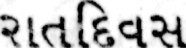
રાતદિવસ
